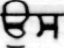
ਉਸ
